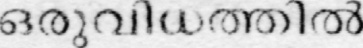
ഒരുവിധത്തില്‍
